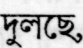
দুলছে,
